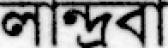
লান্দ্রবা
